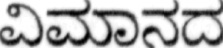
ವಿಮಾನದ
